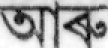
আৰু
